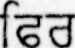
ਫਿਰ
